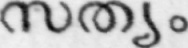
സത്യം
